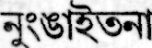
নুংঙাইতনা
